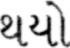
થયો
